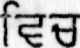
ਵਿਚ
